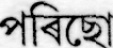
পৰিছো
